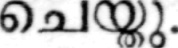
ചെയ്തു.
